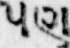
પણ
